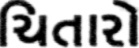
ચિતારો
